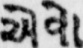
એવો
